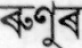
ৰুণুৰ
